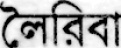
লৈরিবা
